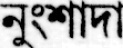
নংশাদা
